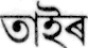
তাইৰ
